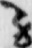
કે
